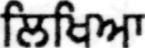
ਲਿਖਿਆ
